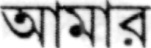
আমার
